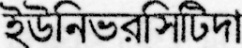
ইউনিভরসিটিদা
